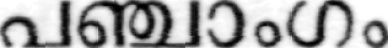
പഞ്ചാംഗം
